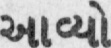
આવ્યો
